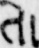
તો
